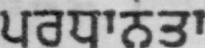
ਪਰਧਾਨਤਾ
